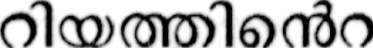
റിയത്തിന്റെ
